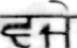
ਵਜੇ
